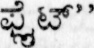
ಫ್ಲೈಟ್”
